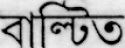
বাল্টিত
